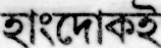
হাংদোকই
